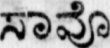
ಸಾವೊ
